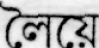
লৈয়ে
